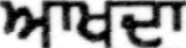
ਆਖਦਾ
